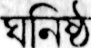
ঘনিষ্ঠ
